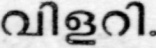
വിളറി.
